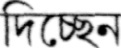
দিচ্ছেন
